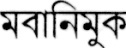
মবানিমু্ক
